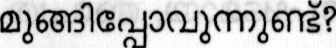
മുങ്ങിപ്പോവുന്നുണ്ട്?
